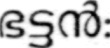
ഭട്ടന്‍:
